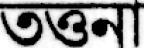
তত্তনা
